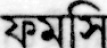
ফমসি
